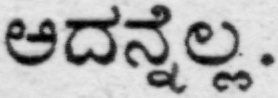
ಅದನ್ನೆಲ್ಲ.
